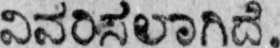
ವಿವರಿಸಲಾಗಿದೆ.
